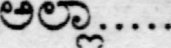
ಅಲ್ಲಾ..........
